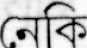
নেকি
